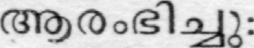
ആരംഭിച്ചു:
